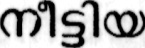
നീട്ടിയ
